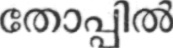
തോപ്പില്‍
